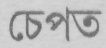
চেপত
